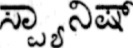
ಸ್ಪ್ಯಾನಿಷ್
